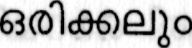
ഒരിക്കലും
